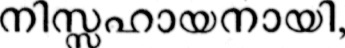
നിസ്സഹായനായി,
